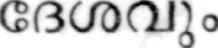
ദേശവും
